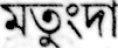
মতুংদা
